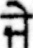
ਜੇ
